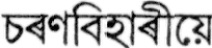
চৰণবিহাৰীয়ে
